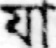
যা
